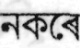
নকৰে
